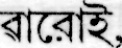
ৱারোই,
